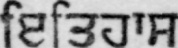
ਇਤਿਹਾਸ
